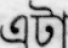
এটা
